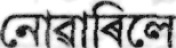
নোৱাৰিলে
